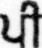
ਪੀ
